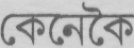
কেনেকৈ
